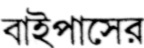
বাইপাসের
